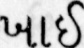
ખાઈ
